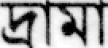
দ্রামা
